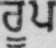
ਰੂਪ
